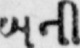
બની
